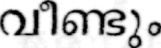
വീണ്ടും
